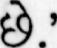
છે.'
